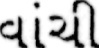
વાંચી
